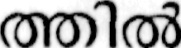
ത്തില്‍
